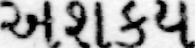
અશક્ય
